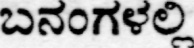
ಬನಂಗಳಲ್ಲಿಯ
